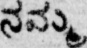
ನಮ್ಮ
